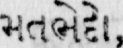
મતભેદો,
